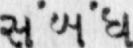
સંબંધ
